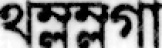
থম্লম্লগা
